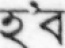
হ'ব
